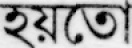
হয়তো
